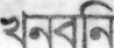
খনবনি
